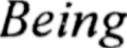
Being
